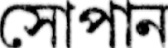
সোপান
